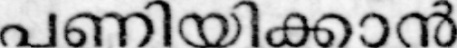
പണിയിക്കാന്‍
